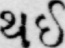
થઈ
